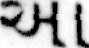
આ
